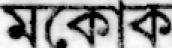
মকোক
